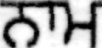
ਨਾਮ
